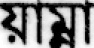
য়াম্না
